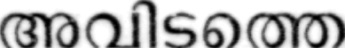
അവിടത്തെ
